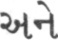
અને
